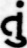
તું
